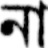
না
